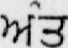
ਅੰਤ
